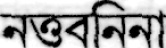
নত্তবনিনা
